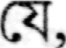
যে,
